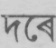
দৰে
